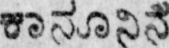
ಕಾನೂನಿನ
